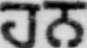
ਹਨ
